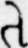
તે
